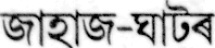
জাহাজ-ঘাটৰ
